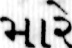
મારે
